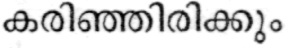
കരിഞ്ഞിരിക്കും
